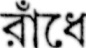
রাঁধে
